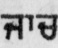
ਜਾਚ
